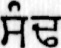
ਸੰਢ
